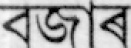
বজাৰ
